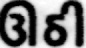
ઊઠી
